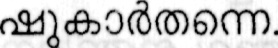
ഷുകാര്‍തന്നെ.
